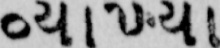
વ્યાખ્યા
